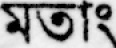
মতাং
